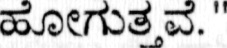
ಹೋಗುತ್ತವೆ.”
